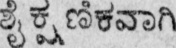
ಶೈಕ್ಷಣಿಕವಾಗಿ
